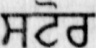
ਸਟੋਰ
